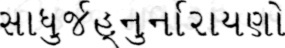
સાધુર્જહનુર્નારાયણો
